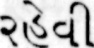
રહેવી
